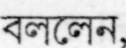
বললেন,
